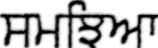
ਸਮਝਿਆ
